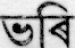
ভৰি
